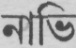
নাভি
